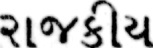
રાજકીય
